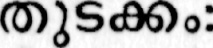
തുടക്കം:
